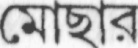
মোছার
